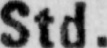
Std.
